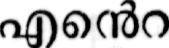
എന്റെ
